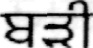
ਬੜੀ
